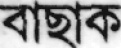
বাছাক
